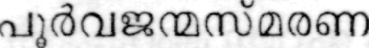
പൂര്‍വജന്മസ്മരണ
